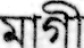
মাগী
